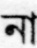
না
